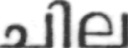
ചില
